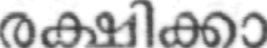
രക്ഷിക്കാ
